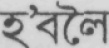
হ'বলৈ
